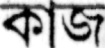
কাজ
